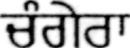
ਚੰਗੇਰਾ
